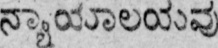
ನ್ಯಾಯಾಲಯವು
